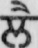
ਲੈ
